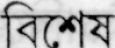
বিশেষ
